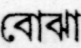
বোঝা
